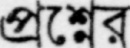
প্রশ্নের
